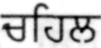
ਚਹਿਲ
